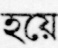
হয়ে
